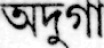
অদুগা
